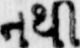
નથી
